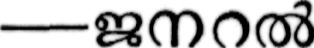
-ജനറല്‍
